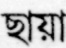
ছায়া
